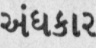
અંધકાર
